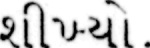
શીખ્યો.
